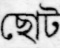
ছোট
